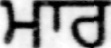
ਮਾਰ
